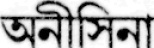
অনীসিনা
